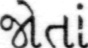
જોતાં
